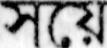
সয়ে
